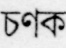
চণক
